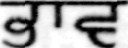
ਭਾਵ
